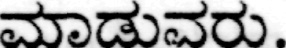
ಮಾಡುವರು.
